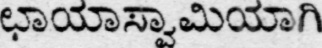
ಛಾಯಾಸ್ವಾಮಿಯಾಗಿ
